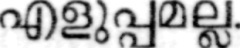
എളുപ്പമല്ല.
